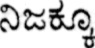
ನಿಜಕ್ಕೂ
